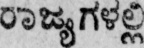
ರಾಜ್ಯಗಳಲ್ಲಿ
